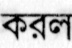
করল
